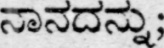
ನಾನದನ್ನು;
